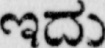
ಇದು
